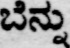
ಬೆನ್ನು
